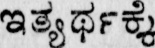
ಇತ್ಯರ್ಥಕ್ಕೆ
